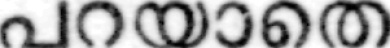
പറയാതെ
